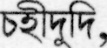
চহীদুদি,
